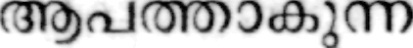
ആപത്താകുന്ന
